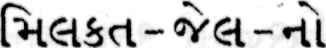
મિલકત-જેલ-નો
